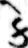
કે
